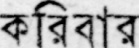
করিবার
